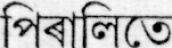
পিৰালিতে
